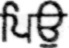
ਪਿਉ
